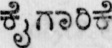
ಕೈಗಾರಿಕೆ
